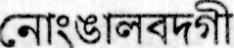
নোংঙালবদগী
